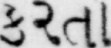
કરવા
